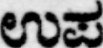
ಉಪ
